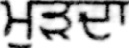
ਮੁੜਦਾ
